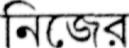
নিজের
